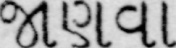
જાણવા
